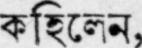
কহিলেন,
